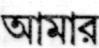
আমার
